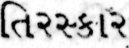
તિરસ્કાર
